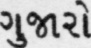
ગુજારો
